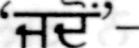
'ਜਦੋਂ'-
